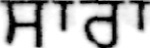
ਸਾਰਾ
